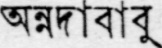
অন্নদাবাবু
